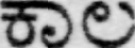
ಕಾಲ
